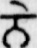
ਨੇ
